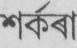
শর্কৰা
